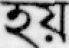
হয়
